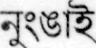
নুংঙাই
